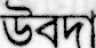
উবদা
